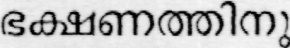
ഭക്ഷണത്തിനു
